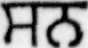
ਸਨ
